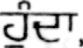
ਹੁੰਦਾ,
